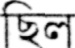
ছিল
